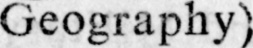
Geography)
